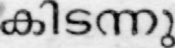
കിടന്നു
